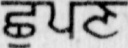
ਛੁਪਣ
